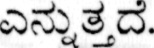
ಎನ್ನುತ್ತದೆ.
